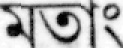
মতাং
